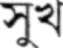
সুখ
